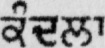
ਕੰਦਲਾ
